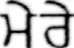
ਮੇਰੇ
